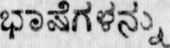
ಭಾಷೆಗಳನ್ನು
